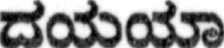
ದಯಯಾ
